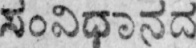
ಸಂವಿಧಾನದ
